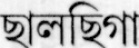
ছালছিগা
